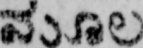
ಮೂಲ
